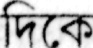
দিকে
